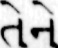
તેને
